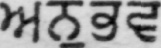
ਅਨੁਭਵ
